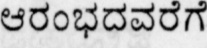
ಆರಂಭದವರೆಗೆ
